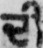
ਦੀ
